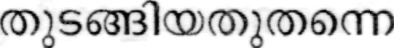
തുടങ്ങിയതുതന്നെ
